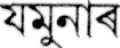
যমুনাৰ
